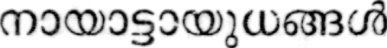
നായാട്ടായുധങ്ങള്‍
